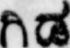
ಗಿಡ
